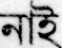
নাই
